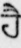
ਹੈ
